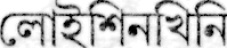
লোইশিনখিনি
